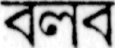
বলব
